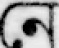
নে
